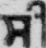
ਸੀ
